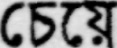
চেয়ে
